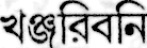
খঞ্জরিবনি
